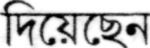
দিয়েছেন
